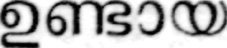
ഉണ്ടായ
